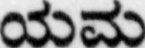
ಯಮ
